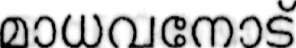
മാധവനോട്
